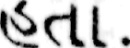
હતા.
